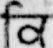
ਕਿ
